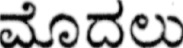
ಮೊದಲು
